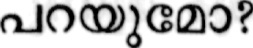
പറയുമോ?
